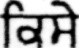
ਕਿਸੇ
